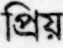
প্রিয়
